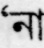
‘না
